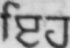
ਇਹ
